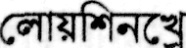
লোয়শিনখ্রে
